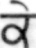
ਕੇ
